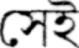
সেই
